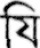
যি
